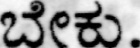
ಬೇಕು.
